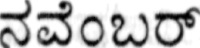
ನವೆಂಬರ್
